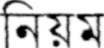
নিয়ম
